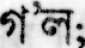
গ'ল;
